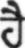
ਹੈ
